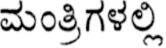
ಮಂತ್ರಿಗಳಲ್ಲಿ
